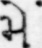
મેં
